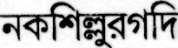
নকশিল্লুরগদি
